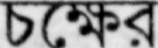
চক্ষের
